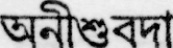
অনীশুবদা
